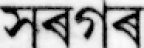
সৰগৰ
